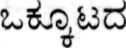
ಒಕ್ಕೂಟದ
